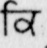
ਕਿ
